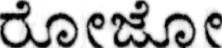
ರೋಜೋ
